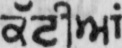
ਕੱਟੀਆਂ
